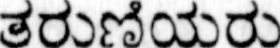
ತರುಣಿಯರು
